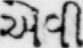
એવી
